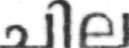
ചില
